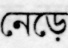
নেড়ে
